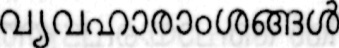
വ്യവഹാരാംശങ്ങള്‍
